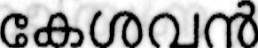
കേശവന്‍
